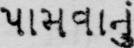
પામવાનું
